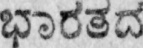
ಭಾರತದ
